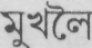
মুখলৈ
